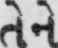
તેને
